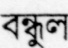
বন্ধুল
